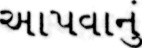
આપવાનું
